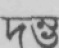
দম্ভ
